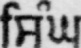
ਸਿੰਘ
